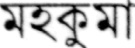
মহকুমা
